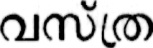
വസ്ത്ര
